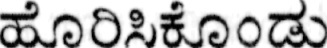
ಹೊರಿಸಿಕೊಂಡು
